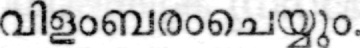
വിളംബരംചെയ്യും.
